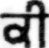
ਕੀ
